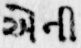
એની
